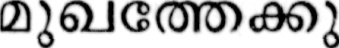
മുഖത്തേക്കു
